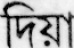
দিয়া
